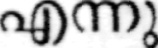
എന്നു
